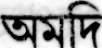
অমদি
